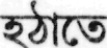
হঠাতে
